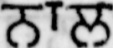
ਨਾਲ
